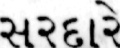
સરદારે
